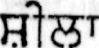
ਸ਼ੀਲਾ
